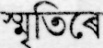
স্মৃতিৰে
